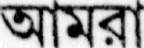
আমরা
